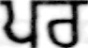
ਪਰ
